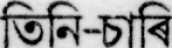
তিনি-চাৰি
